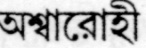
অশ্বারোহী
